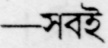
–সবই
